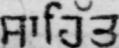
ਸਾਹਿੱਤ
